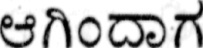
ಆಗಿಂದಾಗ
